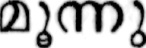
മൂന്നു
